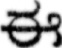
ಈ
